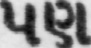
પણ
